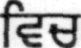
ਵਿਚ
